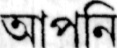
আপনি
